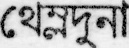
থেম্লদুনা
